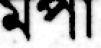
মপা
